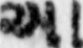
આ
